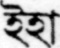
ইহা
